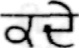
ਕਦੇ
